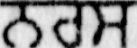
ਨਰਸ
